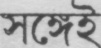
সঙ্গেই
